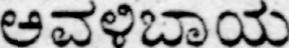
ಅವಳಿಬಾಯ
